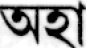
অহা
